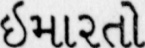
ઈમારતો
